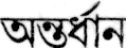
অন্তর্ধান
